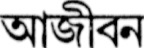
আজীবন
